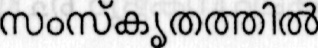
സംസ്കൃതത്തില്‍
